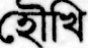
হৌখি
